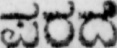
ಪರದೆ
